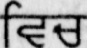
ਵਿਚ
